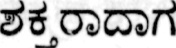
ಶಕ್ತರಾದಾಗ
